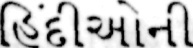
હિંદીઓની
